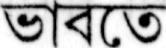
ভাবতে
